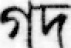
গদ
